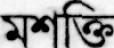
মশক্তি
